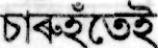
চাৰুহঁতেই
